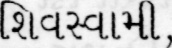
શિવસ્વામી,
